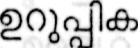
ഉറുപ്പിക
